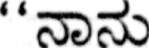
"ನಾನು
